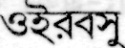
ওইরবসু
